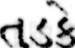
તડકે
